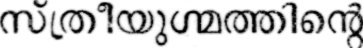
സ്ത്രീയുഗ്മത്തിന്റെ
